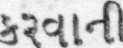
કરવાની
